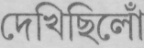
দেখিছিলোঁ
